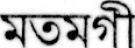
মতমগী
